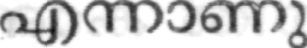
എന്നാണു
